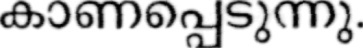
കാണപ്പെടുന്നു.
